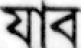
যাব
